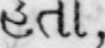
હતા,
